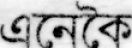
এনেকৈ
